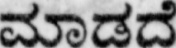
ಮಾಡದೆ
